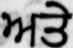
ਅਤੇ
